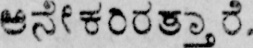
ಅನೇಕರಿರತ್ತಾರೆ.
